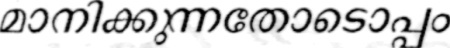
മാനിക്കുന്നതോടൊപ്പം
